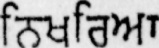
ਨਿਖਰਿਆ
